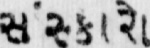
સંસ્કારો
